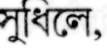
সুধিলে,
